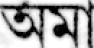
অমা
